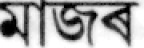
মাজৰ
